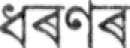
ধৰণৰ
